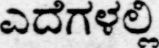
ಎದೆಗಳಲ್ಲಿ
